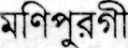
মণিপুরগী
